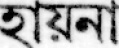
হায়না
